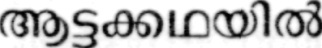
ആട്ടക്കഥയില്‍
